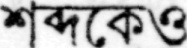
শব্দকেও
